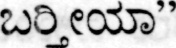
ಬರ್ತೀಯಾ"
